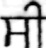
ਸੀ
